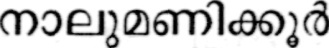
നാലുമണിക്കൂര്‍
